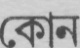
কোন
